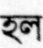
হল
